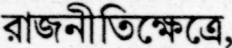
রাজনীতিক্ষেত্রে,
